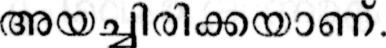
അയച്ചിരിക്കയാണ്.
